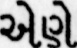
એણે
